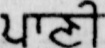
ਪਾਣੀ
